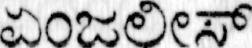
ಏಂಜಲೀಸ್
